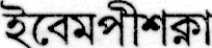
ইবেমপীশক্না
